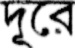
দূরে
